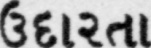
ઉદારતા
